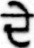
ਦੇ
